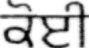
ਕੋਈ
